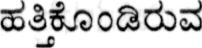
ಹತ್ತಿಕೊಂಡಿರುವ
